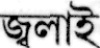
জ্বলাই
